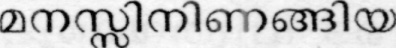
മനസ്സിനിണങ്ങിയ
